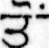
ਤੋਂ
